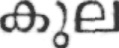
കുല
